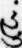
હું
